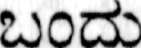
ಬಂದು
